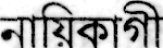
নায়িকাগী
